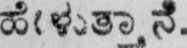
ಹೇಳುತ್ತಾನೆ.
